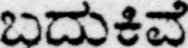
ಬದುಕಿವೆ
